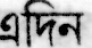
এদিন
